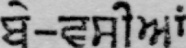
ਬੇ-ਵਸੀਆਂ
